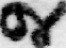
જ
